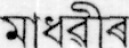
মাধৱীৰ
